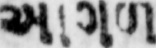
આગળ
